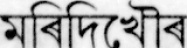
মৰিদিখৌৰ
